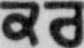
ਕਰ
